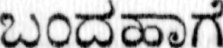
ಬಂದಹಾಗೆ
